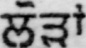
ਲੋੜਾਂ
